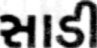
સાડી
